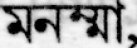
মনম্মা,
